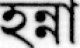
হন্না
